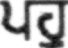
ਪਹੁ
